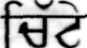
ਚਿੱਟੇ
